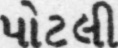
પોટલી
